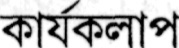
কার্যকলাপ
